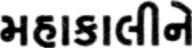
મહાકાલીને
